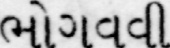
ભોગવવી
